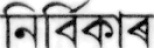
নির্বিকাৰ
